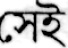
সেই
